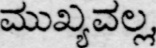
ಮುಖ್ಯವಲ್ಲ,
